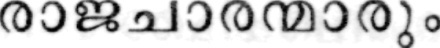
രാജചാരന്മാരും
